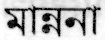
মান্ননা
